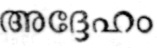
അദ്ദേഹം
